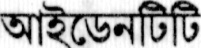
আইডেনটিটি
